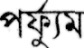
পর্ফ্যুম
